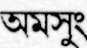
অমসুং
